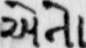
એનો
